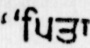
''ਪਿਤਾ
